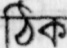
ঠিক
